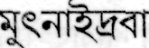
মুৎনাইদ্রবা
